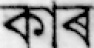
কাৰ
